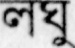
লঘু
